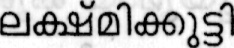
ലക്ഷ്മിക്കുട്ടി
